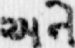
અને
